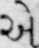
એ
